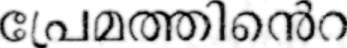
പ്രേമത്തിന്റെ
